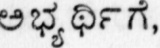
ಅಭ್ಯರ್ಥಿಗೆ,
